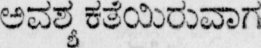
ಅವಶ್ಯಕತೆಯಿರುವಾಗ
